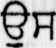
ਉਸ
